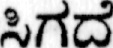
ಸಿಗದೆ
